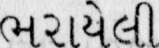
ભરાયેલી
